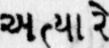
અત્યારે
